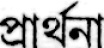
প্রার্থনা
